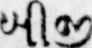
બીજી
